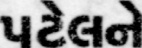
પટેલને
